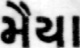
મૈયા
